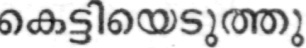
കെട്ടിയെടുത്തു
